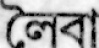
লৈবা
